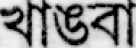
খাঙবা
